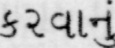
કરવાનું
